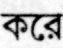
করে
